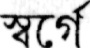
স্বর্গে
